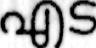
എട
